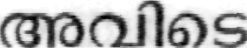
അവിടെ
